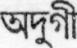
অদুগী
